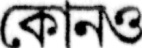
কোনও
